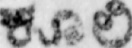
ಕೂಲಿ
